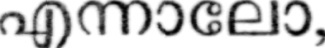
എന്നാലോ,
